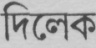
দিলেক
